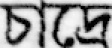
চাদ্রে
